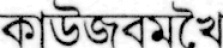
কাউজবমখৈ
